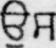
ਉਸ
